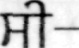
ਸੀ-
